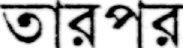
তারপর
